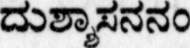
ದುಶ್ಯಾಸನನಂ
